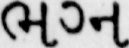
ભગ્ન
